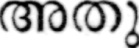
അതു
